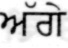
ਅੱਗੇ
